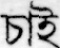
চাই
